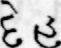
દેહ
